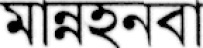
মান্নহনবা
